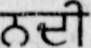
ਨਦੀ
